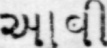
આવી
